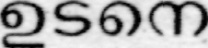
ഉടനെ
